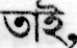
তাই,
